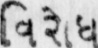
વિરોધ
